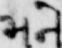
મને
